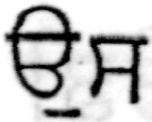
ਉਸ
